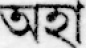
অহা
